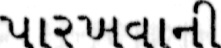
પારખવાની
